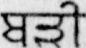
ਬੜੀ
